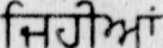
ਜਿਹੀਆਂ
